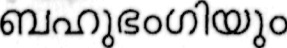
ബഹുഭംഗിയും
